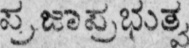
ಪ್ರಜಾಪ್ರಭುತ್ವ
